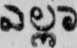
ಎಲ್ಲಾ
